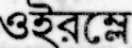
ওইরম্লে
